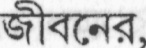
জীবনের,
